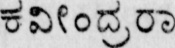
ಕವೀಂದ್ರರಾ’
